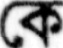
কে
